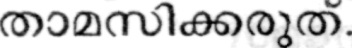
താമസിക്കരുത്.
